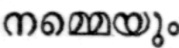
നമ്മെയും
